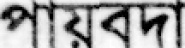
পায়বদা
